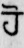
ਹੋ
